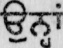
ਉਨ੍ਹਾਂ
